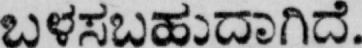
ಬಳಸಬಹುದಾಗಿದೆ.
